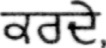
ਕਰਦੇ,
